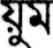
য়ুম
